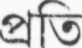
প্রতি
